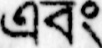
এবং
